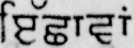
ਇੱਛਾਵਾਂ
